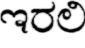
ಇರಲಿ
